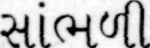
સાંભળી
